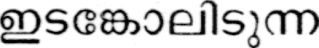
ഇടങ്കോലിടുന്ന
